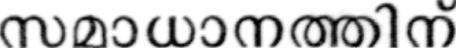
സമാധാനത്തിന്
